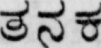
ತನಕ
